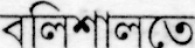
বলিশালতে
